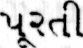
પૂરતી
